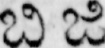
ಬಿಜಿ
